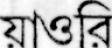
য়াওরি
